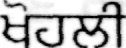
ਖੋਹਲੀ
